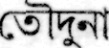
তৌদুনা
